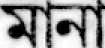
মানা
